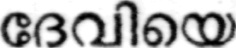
ദേവിയെ
